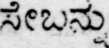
ಸೇಬನ್ನು
